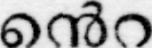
ന്റെ
